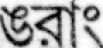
ঙরাং
